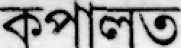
কপালত
